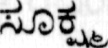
ಸೂಕ್ಷ್ಮ
